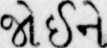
જોઈને
